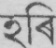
হৰি
